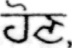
ਹੋਣ,
